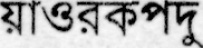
য়াওরকপদু
